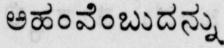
ಅಹಂವೆಂಬುದನ್ನು
